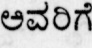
ಅವರಿಗೆ
